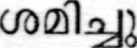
ശമിച്ചു
